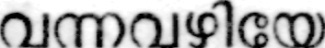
വന്നവഴിയേ
